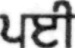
ਪਈ
